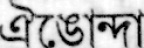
ঐঙোন্দা
